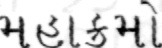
મહાક્રમો
